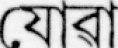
যোৱা
